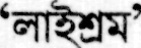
‘লাইশ্রম’
